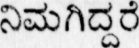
ನಿಮಗಿದ್ದರೆ
